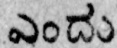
ಎಂದು
